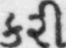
કરી
